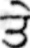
ਤੇ
